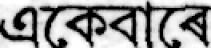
একেবাৰে
